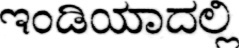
ಇಂಡಿಯಾದಲ್ಲಿ
